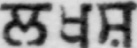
ਲਖਸ਼
